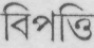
বিপত্তি
